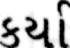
કર્યા
